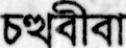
চত্থবীবা
